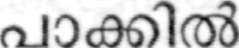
പാക്കില്‍
